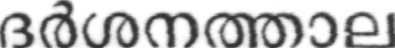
ദര്‍ശനത്താല
